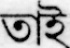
তাই
